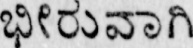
ಭೀರುವಾಗಿ
